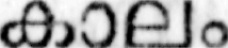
കാലം
